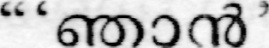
"ഞാന്‍'
